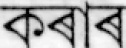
কৰাৰ
